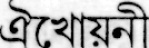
ঐখোয়নী
